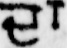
ਦਾ
